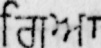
ਗਿਆ
